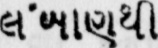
લંબાણથી
